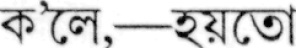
ক'লে,-হয়তো
